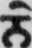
ਨੇ
